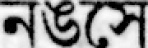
নঙসে
